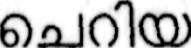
ചെറിയ
